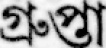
গ্রুপ্তা
